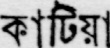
কাটিয়া
